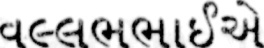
વલ્લભભાઈએ
